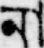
না
